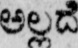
ಅಲ್ಲದೆ
